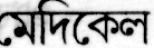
মেদিকেল
